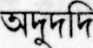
অদুদদি
